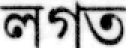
লগত
